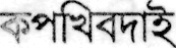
কপখিবদাই
